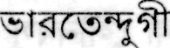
ভারতেন্দুগী
